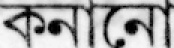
কনানো
